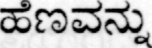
ಹೆಣವನ್ನು
